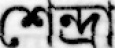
শেন্দ্রা
